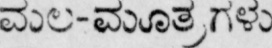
ಮಲ-ಮೂತ್ರಗಳು
